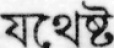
যথেষ্ট
